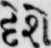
દેશે
